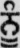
ਨੂੰ
